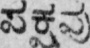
ಪಕ್ಷವು
